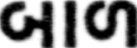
બાળ
